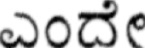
ಎಂದೇ
